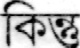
কিন্তু
